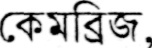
কেমব্রিজ,
